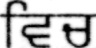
ਵਿਚ
